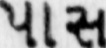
પાસ
